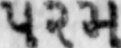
પરમ
